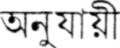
অনুযায়ী
